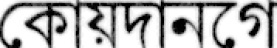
কোয়দানগে
